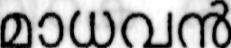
മാധവന്‍
